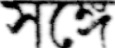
সঙ্গে
